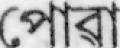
পোৱা
